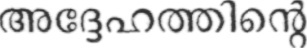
അദ്ദേഹത്തിന്റെ
